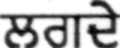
ਲਗਦੇ
